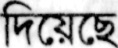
দিয়েছে
